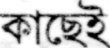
কাছেই
